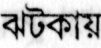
ঝটকায়
